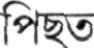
পিছত
